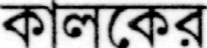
কালকের
